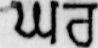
ਘਰ
